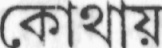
কোথায়
